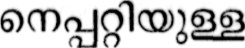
നെപ്പറ്റിയുള്ള
